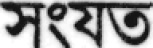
সংযত
